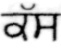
ਕੱਸ
